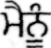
ਮੈਨੂੰ
